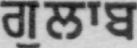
ਗੁਲਾਬ
